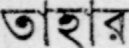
তাহার
